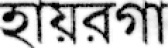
হায়রগা
